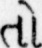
તો
